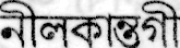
নীলকান্তগী
